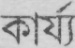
কাৰ্য্য
